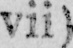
vii)
